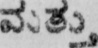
ಮತ್ತು
